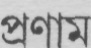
প্ৰণাম
